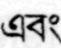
এবং
